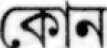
কোন
